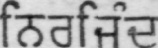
ਨਿਰਜਿੰਦ
